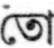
তো
